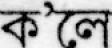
ক'লে
